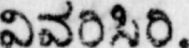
ವಿವರಿಸಿರಿ.
